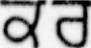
ਕਰ
